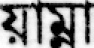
য়াম্না
